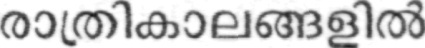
രാത്രികാലങ്ങളില്‍
